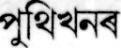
পুথিখনৰ
